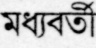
মধ্যবর্তী
